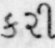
કરી
